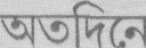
অতদিনে
